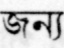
জন্য
